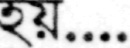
হয়....
